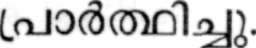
പ്രാര്‍ത്ഥിച്ചു.
